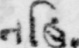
નહિ.
